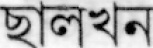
ছালখন
